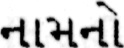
નામનો
